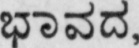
ಭಾವದ,
